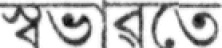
স্বভাৱতে
